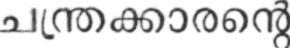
ചന്ത്രക്കാരന്റെ
